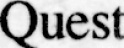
Quest
